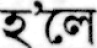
হ'লে
